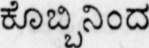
ಕೊಬ್ಬಿನಿಂದ
